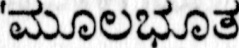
ಮೂಲಭೂತ
